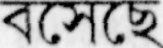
বসেছে
